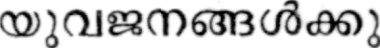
യുവജനങ്ങള്‍ക്കു
